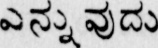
ಎನ್ನುವುದು
